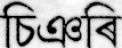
চিঞৰি
